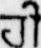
ਹੀ
